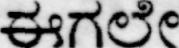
ಈಗಲೇ
